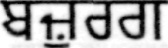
ਬਜ਼ੁਰਗ
